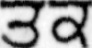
ਤਕ
